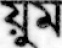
য়ুম
